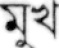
মুখ
